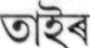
তাইৰ
